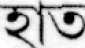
হাত
